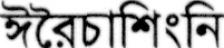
ঈরৈচাশিংনি
